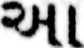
આ
